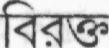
বিরক্ত
